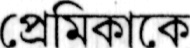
প্রেমিকাকে
